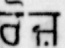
ਰੋਜ਼
